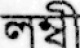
লম্বী
